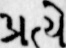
પ્રત્યે
